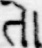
તો
